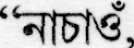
"নাচাওঁ,
